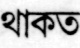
থাকত
